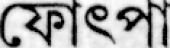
ফোৎপা
